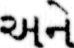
અને
